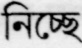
নিচ্ছে
